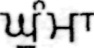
ਘੁੰਮਾ
